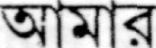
আমার
